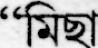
"মিছা
